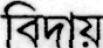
বিদায়
